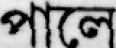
পালে
